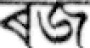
ৰজ
